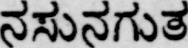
ನಸುನಗುತ
